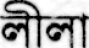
লীলা
